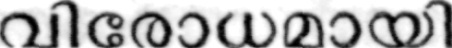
വിരോധമായി
